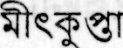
মীৎকুপ্তা
